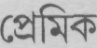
প্ৰেমিক
